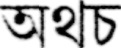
অথচ
